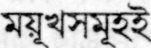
ময়ূখসমূহই
